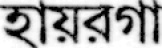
হায়রগা
